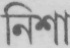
নিশা
